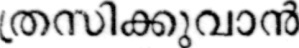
ത്രസിക്കുവാന്‍
